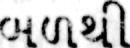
બળથી
